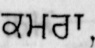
ਕਮਰਾ,
